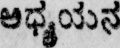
ಅಧ್ಯಯನ
